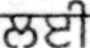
ਲਈ
